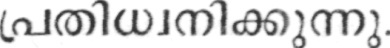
പ്രതിധ്വനിക്കുന്നു.
